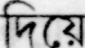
দিয়ে
